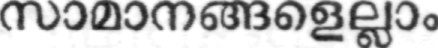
സാമാനങ്ങളെല്ലാം
